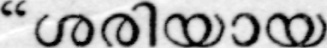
"ശരിയായ
